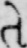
તે
